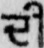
ਦੀ
